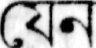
যেন
